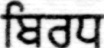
ਬਿਰਧ
